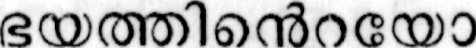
ഭയത്തിന്റെയോ
